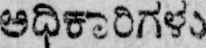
ಅಧಿಕಾರಿಗಳು
